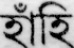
হাঁহি
